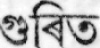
গুৰিত
